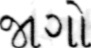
જાગો
